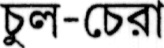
চুল-চেরা
